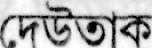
দেউতাক
